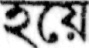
হয়ে
